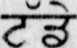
ਟੱਡੇ
